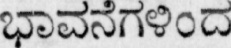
ಭಾವನೆಗಳಿಂದ
